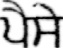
ਪੈਸੇ
